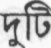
দুটি
